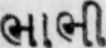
ભાભી
